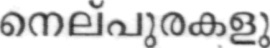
നെല്പുരകളു
